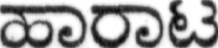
ಹಾರಾಟ
